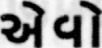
એવો
